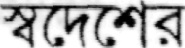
স্বদেশের
